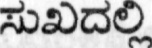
ಸುಖದಲ್ಲಿ
